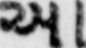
આ
